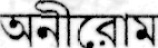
অনীরোম
